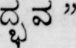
ದ್ಭವ”
